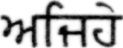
ਅਜਿਹੇ
